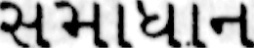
સમાધાન
